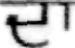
ਦਾ
